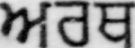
ਅਰਥ
